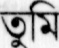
তুমি
